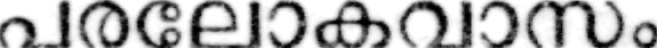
പരലോകവാസം
